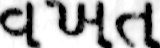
વખત
